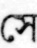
সে
